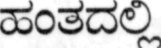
ಹಂತದಲ್ಲಿ
